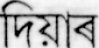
দিয়াৰ
